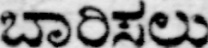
ಬಾರಿಸಲು
